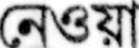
নেওয়া
